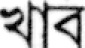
খাব
